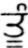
ਤੂੰ
